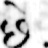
છે.
